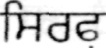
ਸਿਰਫ਼
